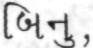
બિનુ,
